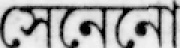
সেনেনো
